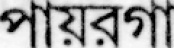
পায়রগা
